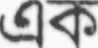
এক
